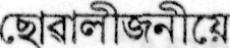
ছোৱালীজনীয়ে
